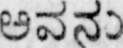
ಅವನು
